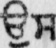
ਉਸ
